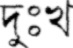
দুঃখ
